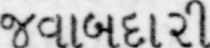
જવાબદારી
